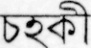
চহকী
